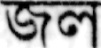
জল
